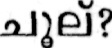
ചൂല്?
